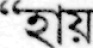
“হায়
